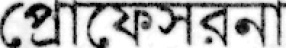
প্রোফেসরনা
